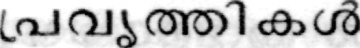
പ്രവൃത്തികള്‍
